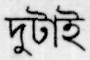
দুটাই
